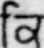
ਕਿ
